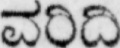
ವರಿದಿ
